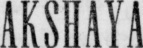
AKSHAYA
